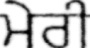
ਮੇਰੀ
